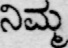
ನಿಮ್ಮ
